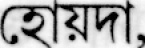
হোয়দা,
